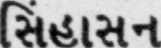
સિંહાસન
